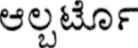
ಆಲ್ಬರ್ಟೊ
